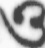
ও
